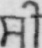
ਸੀ
